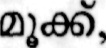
മൂക്ക്,
